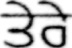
ਤੇਰੇ
